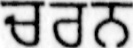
ਚਰਨ
